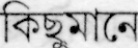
কিছুমানে
